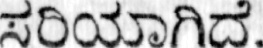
ಸರಿಯಾಗಿದೆ.
